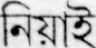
নিয়াই
